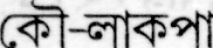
কৌ-লাকপা
